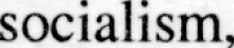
socialism,
